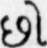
છો
